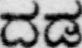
ದಡ
